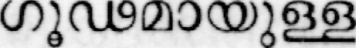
ഗൂഢമായുള്ള
